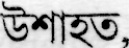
উশাহত,
